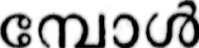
മ്പോള്‍
